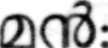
മന്‍:
